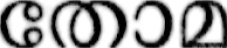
തോമ
